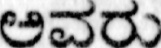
ಅವರು
